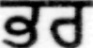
ਭਰ
